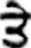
ਤੇ
